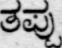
ತಪ್ಪು
